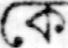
কে
